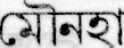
মৌনহা
